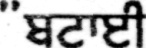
''ਬਟਾਈ
